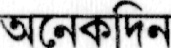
অনেকদিন
